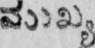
ಮುಖ್ಯ
